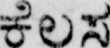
ಕೆಲಸ
